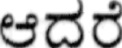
ಆದರೆ
